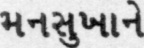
મનસુખાને
